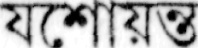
যশোয়ন্ত
